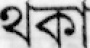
থকা
